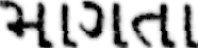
માગતા
